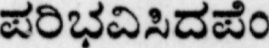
ಪರಿಭವಿಸಿದಪೆಂ
